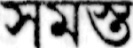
সমস্ত
